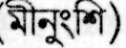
(মীনুংশি)
